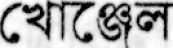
খোঞ্জেল
